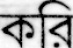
করি
